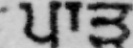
ਪਾੜ
